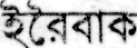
ইরৈবাক
